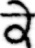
ਕੇ
